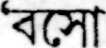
‘বসো
